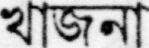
খাজনা
